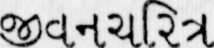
જીવનચરિત્ર
